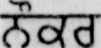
ਨੌਕਰ
